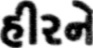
હીરને
